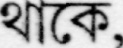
থাকে,
